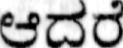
ಆದರೆ
